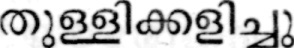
തുള്ളിക്കളിച്ചു
